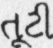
તૂટી
